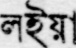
লইয়া
